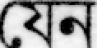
যেন
